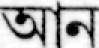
আন
